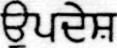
ਉਪਦੇਸ਼
